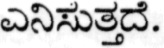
ಎನಿಸುತ್ತದೆ.
